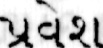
પ્રવેશ
